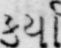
કર્યા
